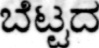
ಬೆಟ್ಟದ
